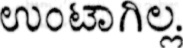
ಉಂಟಾಗಿಲ್ಲ.
